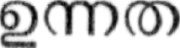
ഉന്നത
